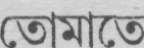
তোমাতে
